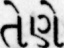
તેણે
